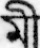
মী
